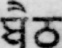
ਬੈਠ
